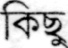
কিছু
